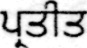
ਪ੍ਰਤੀਤ
